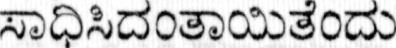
ಸಾಧಿಸಿದಂತಾಯಿತೆಂದು
